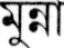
মুন্না
